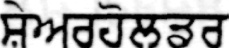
ਸ਼ੇਅਰਹੋਲਡਰ
